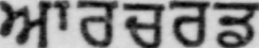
ਆਰਚਰਡ
